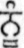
ਨੂੰ
